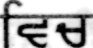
ਵਿਚ
